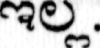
ಇಲ್ಲ.
